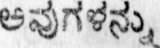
ಅವುಗಳನ್ನು
